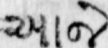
આજે
